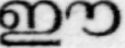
ഈ
